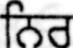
ਨਿਰ
